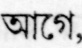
আগে,
